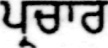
ਪ੍ਰਚਾਰ
